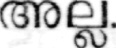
അല്ല.
